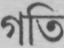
গতি
